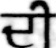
ਦੀ
